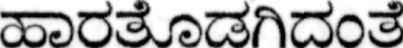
ಹಾರತೊಡಗಿದಂತೆ
